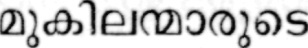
മുകിലന്മാരുടെ
